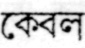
কেবল
